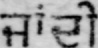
ਜਾਂਦੀ
